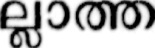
ല്ലാത്ത
